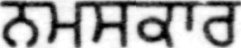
ਨਮਸਕਾਰ
